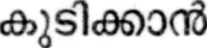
കുടിക്കാന്‍
